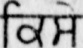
ਕਿਸੇ
